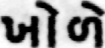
ખોળે
